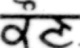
ਕੌਣ
